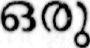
ഒരു
